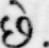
છે.
